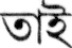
তাই
